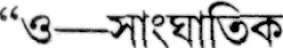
"ও-সাংঘাতিক
